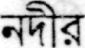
নদীর
